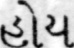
હોય
